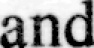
and
